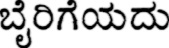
ಬೈರಿಗೆಯದು
